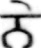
ਨੇ
